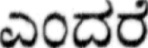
ಎಂದರೆ
